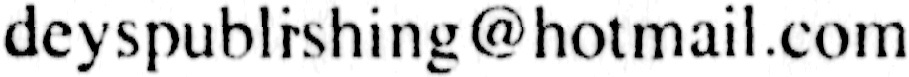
deypublishing@hotmail.com
